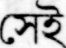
সেই
